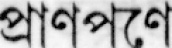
প্রাণপণে
